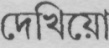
দেখিয়ো
